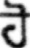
ਹੋ
